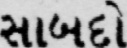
સાબદો
